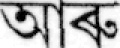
আৰু
